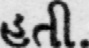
હતી.
